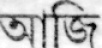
আজি
